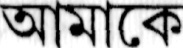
আমাকে
